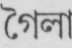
গৈলা
